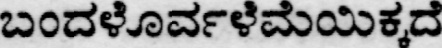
ಬಂದಳೊರ್ವಳೆಮೆಯಿಕ್ಕದೆ
